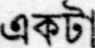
একটা
